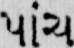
પાંચ
